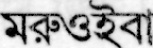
মরুওইবা
